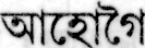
আহোগৈ
